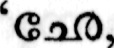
'ഛേ,
